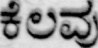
ಕೆಲವು
